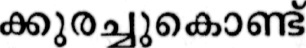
ക്കുരച്ചുകൊണ്ട്
